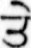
ਤੇ
